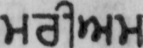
ਮਰੀਅਮ
